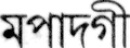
মপাদগী
